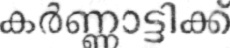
കര്‍ണ്ണാട്ടിക്ക്
